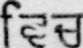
ਵਿਚ
